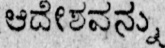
ಆದೇಶವನ್ನು
